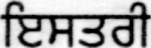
ਇਸਤਰੀ
